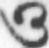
ও
